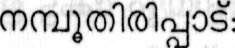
നമ്പൂതിരിപ്പാട്:
